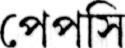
পেপসি
